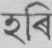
হৰি
